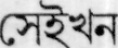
সেইখন
